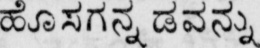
ಹೊಸಗನ್ನಡವನ್ನು
